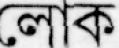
লোক
